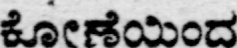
ಕೋಣೆಯಿಂದ
